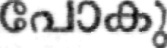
പോകു
